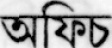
অফিচ
